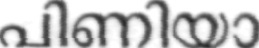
പിണിയാ
